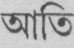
আতি
